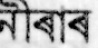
নীৰাৰ
